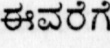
ಈವರೆಗೆ
